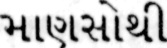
માણસોથી
